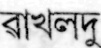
ৱাখলদু
